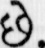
છે.
